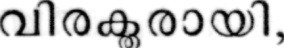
വിരക്തരായി,
